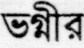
ভগ্নীর
